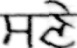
ਸਣੇ
